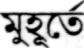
মুহূর্তে
